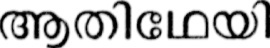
ആതിഥേയി
